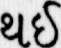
થઈ
